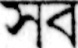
সব
